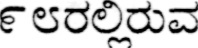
೯೮ರಲ್ಲಿರುವ
